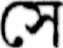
সে
